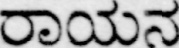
ರಾಯನ
